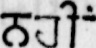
ਨਹੀਂ
